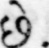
છે.
